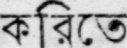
করিতে
